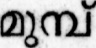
മുമ്പ്
